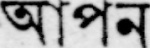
আপন
